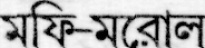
মফি-মরোল
